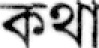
কথা
